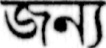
জন্য
